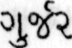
ગુર્જર
